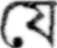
যে
